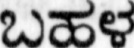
ಬಹಳ
